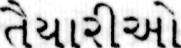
તૈયારીઓ
